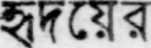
হৃদয়ের
